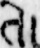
તો
